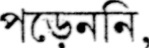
পড়েননি,
